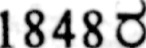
1848ರ
